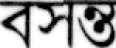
বসন্ত
